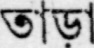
তাড়া
